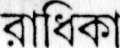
রাধিকা
